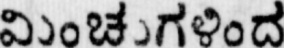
ಮಿಂಚುಗಳಿಂದ
